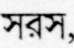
সরস,
